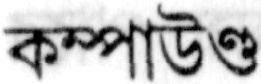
কম্পাউন্ড
